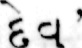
દેવ'
